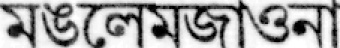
মঙলেমজাওনা
